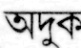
অদুক
